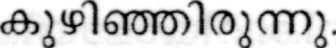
കുഴിഞ്ഞിരുന്നു.
